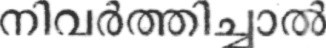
നിവര്‍ത്തിച്ചാല്‍
